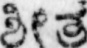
ಶೀತ
